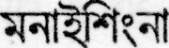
মনাইশিংনা
